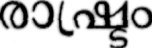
രാഷ്ട്രം
